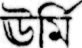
ঊর্মি
